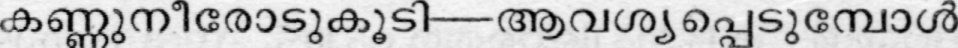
കണ്ണുനീരോടുകൂടി-ആവശ്യപ്പെടുമ്പോള്‍
